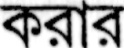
করার
